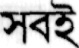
সবই
